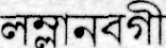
লম্নানবগী
